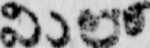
ಮಿಲ್
